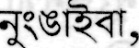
নুংঙাইবা,
